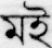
মই
